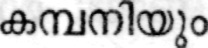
കമ്പനിയും
